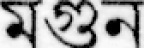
মগুন
